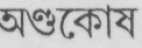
অণ্ডকোষ
